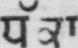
ਧੱਕਾ
